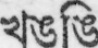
খঙঙি
